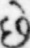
છે
